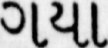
ગયા
